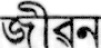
জীৱন
